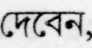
দেবেন,
